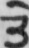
ਤੇ
